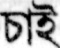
চাই
